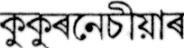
কুকুৰনেচীয়াৰ
